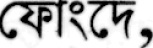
ফোংদে,
